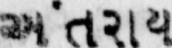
અંતરાય
